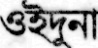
ওইদুনা
